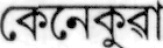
কেনেকুৱা
